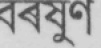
বৰষুণ
